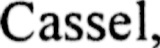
Cassel,
